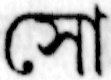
সো
